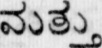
ಮತ್ತು
